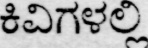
ಕಿವಿಗಳಲ್ಲಿ
